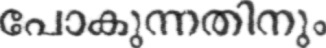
പോകുന്നതിനും
